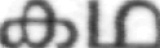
കഥ
